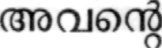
അവന്റെ
